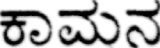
ಕಾಮನ
